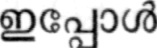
ഇപ്പോള്‍
